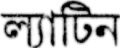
ল্যাটিন
